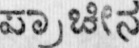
ಪ್ರಾಚೀನ
